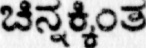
ಚಿನ್ನಕ್ಕಿಂತ
